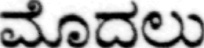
ಮೊದಲು
